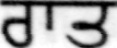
ਰਾਤ
